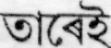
তাৰেই
